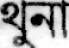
থুনা
